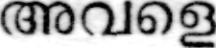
അവളെ
